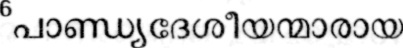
6പാണ്ഡ്യദേശീയന്മാരായ
